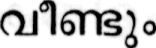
വീണ്ടും
